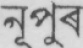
নূপুৰ
